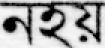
নহয়
